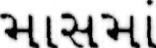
માસમાં
